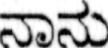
ನಾನು
